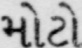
મોટો
